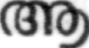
ആ
